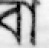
বা
